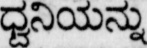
ಧಧ್ವನಿಯನ್ನು
